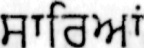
ਸਾਰਿਆਂ
